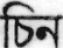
চিন
